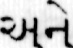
અને
